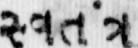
સ્વતંત્ર
